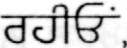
ਰਹੀਓਂ,
